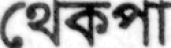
থেকপা
